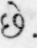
છે.
